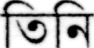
তিনি
